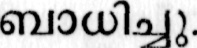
ബാധിച്ചു.
